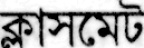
ক্লাসমেট
